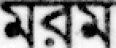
মরম
